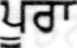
ਪੂਰਾ
